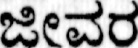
ಜೀವರ
